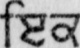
ਇਕ
